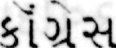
કોંગ્રેસ
